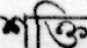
শক্তি
